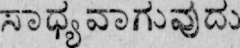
ಸಾಧ್ಯವಾಗುವುದು
